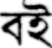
বই
